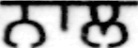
ਨਾਲ
